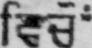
ਵਿਚੋਂ
